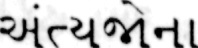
અંત્યજોના
